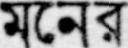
মনের
